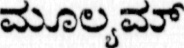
ಮೂಲ್ಯಮ್
